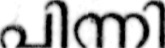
പിന്നി
